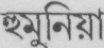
হুমুনিয়া
